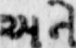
અને
